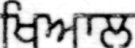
ਖਿਆਲ
